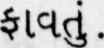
ફાવતું.
